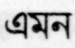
এমন
